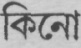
কিনো
